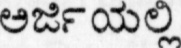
ಅರ್ಜಿಯಲ್ಲಿ
